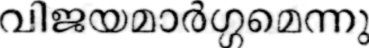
വിജയമാര്‍ഗ്ഗമെന്നു
